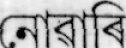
নোৱাৰি
